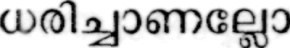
ധരിച്ചാണല്ലോ
